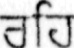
ਰਹਿ
